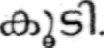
കൂടി.
